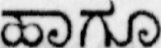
ಹಾಗೂ
